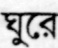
ঘুরে
